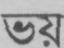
ভয়
